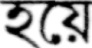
হয়ে
